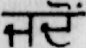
ਜਦੋਂ
